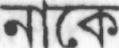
নাকে
